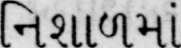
નિશાળમાં
